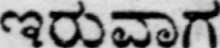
ಇರುವಾಗ
